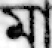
মা
